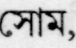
সোম,
